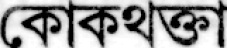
কোকথক্তা
